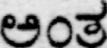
ಅಂತ
